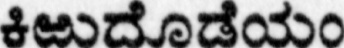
ಕಿಱುದೊಡೆಯಂ
